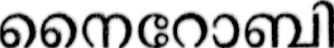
നൈറോബി
